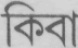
কিবা
